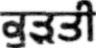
ਕੁੜਤੀ
